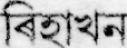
ৰিহাখন
